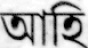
আহি
